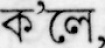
ক'লে,
